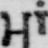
ਮਾਂ
